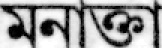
মনাক্তা
